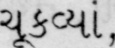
ચૂકવ્યાં,
